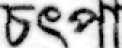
চৎপা
